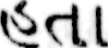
હતા
